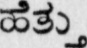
ಹೆತ್ತು
